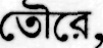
তৌরে,
